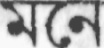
মনে
